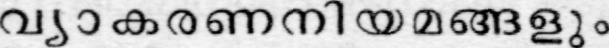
വ്യാകരണനിയമങ്ങളും
